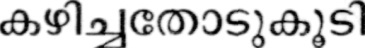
കഴിച്ചതോടുകൂടി
